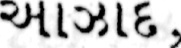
આઝાદ,
